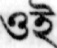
ওই
